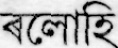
ৰলোহি
